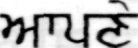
ਆਪਣੇ
